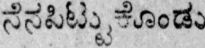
ನೆನಪಿಟ್ಟುಕೊಂಡು
